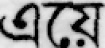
এয়ে
